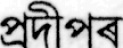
প্ৰদীপৰ
